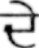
ਦੇ
